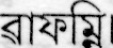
ৱাফম্নি।
